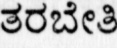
ತರಬೇತಿ
